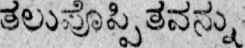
ತಲುಪೊಪ್ಪಿತವನ್ನು
